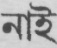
নাই
